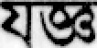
যজ্ঞ
